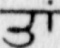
ਤਾਂ
